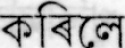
কৰিলে
